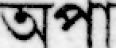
অপা
